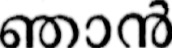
ഞാന്‍
